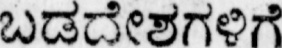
ಬಡದೇಶಗಳಿಗೆ
